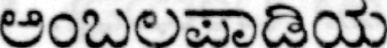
ಅಂಬಲಪಾಡಿಯ
